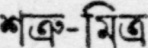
শত্রু-মিত্র
